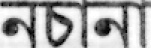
নচানা
